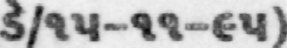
ડે/૧૫-૧૧-૯૫)
